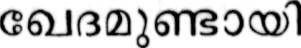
ഖേദമുണ്ടായി
